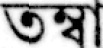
তম্বা
